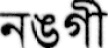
নঙগী
